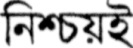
নিশ্চয়ই
